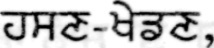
ਹਸਣ-ਖੇਡਣ,
